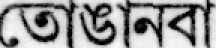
তোঙানবা
